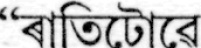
"ৰাতিটোৱে
